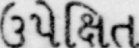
ઉપેક્ષિત
